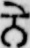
ਨੇ
